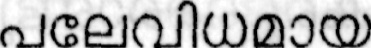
പലേവിധമായ
